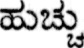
ಹುಚ್ಚು
